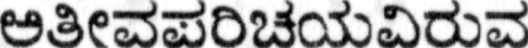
ಅತೀವಪರಿಚಯವಿರುವ
